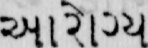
આરોગ્ય
